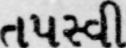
તપસ્વી
